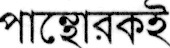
পান্থোরই
